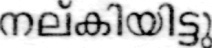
നല്കിയിട്ടു
